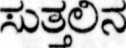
ಸುತ್ತಲಿನ
